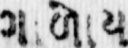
ગાળોય
